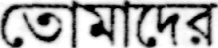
তোমাদের
